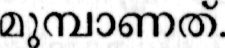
മുമ്പാണത്.
